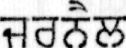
ਜਰਨੈਲ
